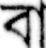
বা
